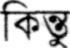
কিন্তু
